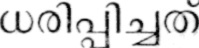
ധരിപ്പിച്ചത്
